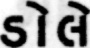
ડોલે
